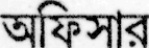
অফিসার
